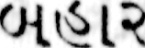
બહાર
